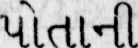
પોતાની
